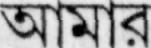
আমার
